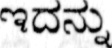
ಇದನ್ನು
